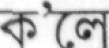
ক'লে
